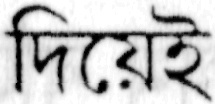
দিয়েই
